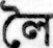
লৈ
